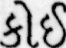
કોઈ
